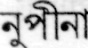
নুপীনা
